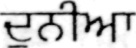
ਦੁਨੀਆ
